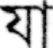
যা
